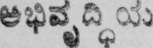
ಅಭಿವೃದ್ಧಿಯ
